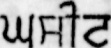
ਘਸੀਟ
